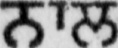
ਨਾਲ
